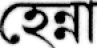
হেন্না
